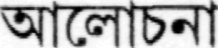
আলোচনা
